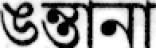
ঙন্তানা
